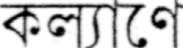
কল্যাণে
